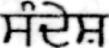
ਸੰਦੇਸ਼
